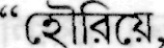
“হৌরিয়ে,
